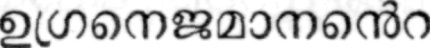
ഉഗ്രനെജമാനന്റെ
